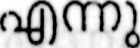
എന്നു
